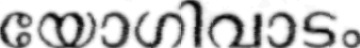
യോഗിവാടം
